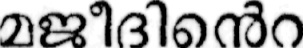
മജീദിന്റെ
